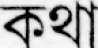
কথা
